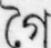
গৈ
